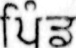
ਪਿੰਡ
